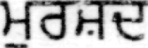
ਮੁਰਸ਼ਦ
